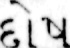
દોષ
